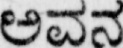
ಅವನ
